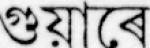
গুয়াৰে
